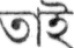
তাই
